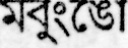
মবুংঙো
